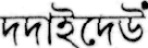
দদাইদেউ
